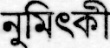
নুমিৎকী
